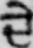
ਦੇ
